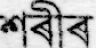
শৰীৰ
